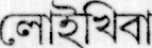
লোইখিবা
